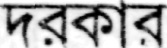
দরকার
